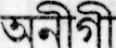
অনীগী
